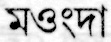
মওংদা
